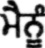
ਮੈਨੂੰ
